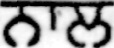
ਨਾਲ
